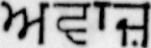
ਅਵਾਜ਼
